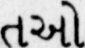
તઓ
